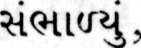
સંભાળ્યું,
